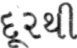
દૂરથી
